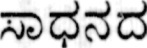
ಸಾಧನದ
